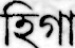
হিগা
